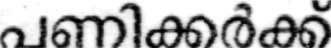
പണിക്കര്‍ക്ക്
